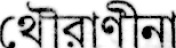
থৌরাণীনা
